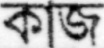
কাজ
